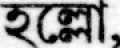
হল্লো,
